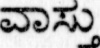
ವಾಸ್ತು
